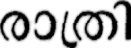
രാത്രി
